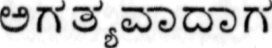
ಅಗತ್ಯವಾದಾಗ
